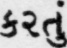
કરતું
